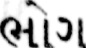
ભોગ
